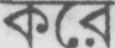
করে
